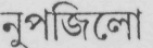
নুপজিলো
